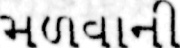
મળવાની
